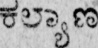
ಕಲ್ಯಾಣ
